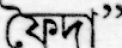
ফৈদা”
